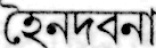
হৈনদবনা
